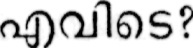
എവിടെ?
